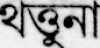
থত্তুনা
